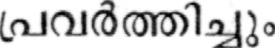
പ്രവര്‍ത്തിച്ചും
